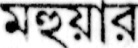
মহুয়ার
